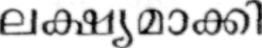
ലക്ഷ്യമാക്കി
